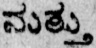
ಮತ್ತು
